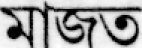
মাজত
